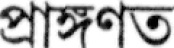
প্রাঙ্গণত
